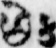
છેક
